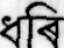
ধৰি
